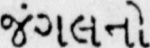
જંગલનો
